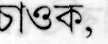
চাওক,
